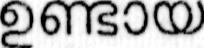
ഉണ്ടായ
